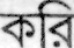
করি
